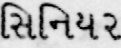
સિનિયર
